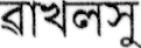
ৱাখলসু
